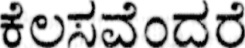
ಕೆಲಸವೆಂದರೆ
